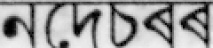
নদেচৰৰ
